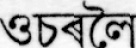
ওচৰলৈ
